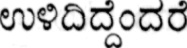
ಉಳಿದಿದ್ದೆಂದರೆ
